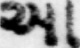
આ
